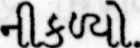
નીકળ્યો.
